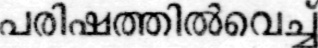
പരിഷത്തില്‍വെച്ച്
